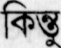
কিন্তু
